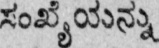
ಸಂಖ್ಯೆಯನ್ನು
